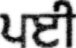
ਪਈ
